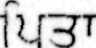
ਪਿਤਾ
